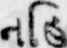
નહિં
